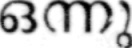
ഒന്നു
